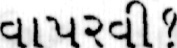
વાપરવી?
